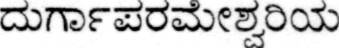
ದುರ್ಗಾಪರಮೇಶ್ವರಿಯ
